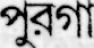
পুরগা
